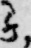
કે,
